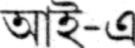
আই-এ
